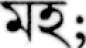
মহ;
